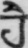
ਹੈ
